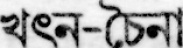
খৎন-চৈনবা
